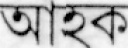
আহক
